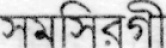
সমসিরগী
